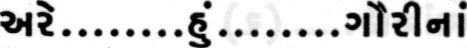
અરે........હું........ગૌરીનાં
